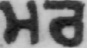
ਮਰ
